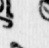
પણ
